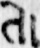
તો
